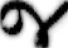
જ
